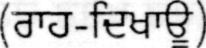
(ਰਾਹ-ਦਿਖਾਊ)
